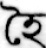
হৈ
